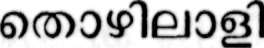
തൊഴിലാളി
